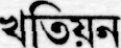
খতিয়ন
